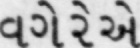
વગેરેએ
